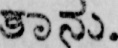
ತಾನು.
